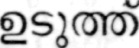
ഉടുത്ത്
